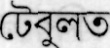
টেবুলত
